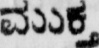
ಮುಕ್ತ
